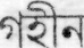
গহীন
